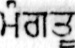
ਮੰਗਤੂ
